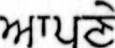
ਆਪਣੇ
